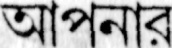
আপনার
